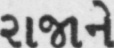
રાજાને
